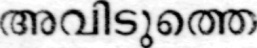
അവിടുത്തെ
